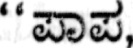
"ಪಾಪ,
